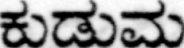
ಕುಡುಮ
